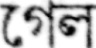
গেল
